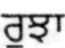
ਰੁਝਾ
